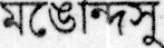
মঙোন্দসু
